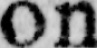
on
